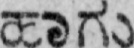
ಹಾಗು
